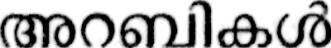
അറബികള്‍
